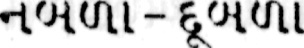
નબળા-દૂબળા
